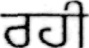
ਰਹੀ
